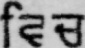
ਵਿਚ
